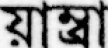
য়াম্বা
